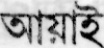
আয়াই
